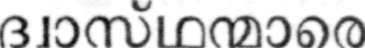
ദ്വാസ്ഥന്മാരെ
